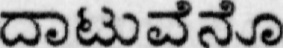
ದಾಟುವೆನೊ
